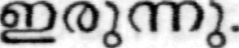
ഇരുന്നു.
